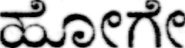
ಹೋಗೇ
